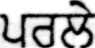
ਪਰਲੇ
